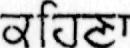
ਕਹਿਣਾ
